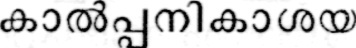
കാല്‍പ്പനികാശയ
